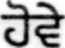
ਹੋਵੇ
